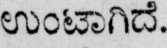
ಉಂಟಾಗಿದೆ.
